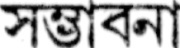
সম্ভাবনা
